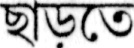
ছাড়তে
